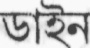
ডাইন
